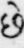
છે
